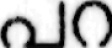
പറ
